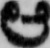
ಆ
